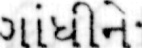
ગાંધીનેઃ
